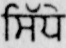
ਸਿੱਧੇ
